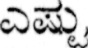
ಎಷ್ಟು
